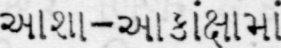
આશા-આકાક્ષામાં
